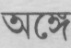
অঙ্গে
